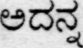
ಅದನ್ನ
